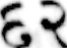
દર
